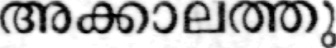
അക്കാലത്തു
